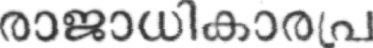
രാജാധികാരപ്ര
